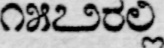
೧೫೭೨ರಲ್ಲಿ
